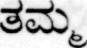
ತಮ್ಮ
